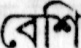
বেশি
